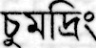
চুমদ্রিং
